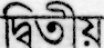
দ্বিতীয়
